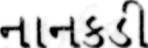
નાનકડી
